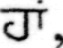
ਹਾਂ,
